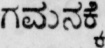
ಗಮನಕ್ಕೆ
